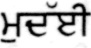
ਮੁਦੱਈ
